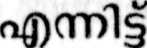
എന്നിട്ട്
